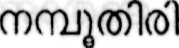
നമ്പൂതിരി
